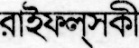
রাইফলসকী
